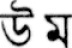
উম
